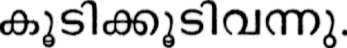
കൂടിക്കൂടിവന്നു.
